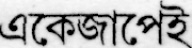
একেজাপেই
